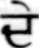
ਦੇ
